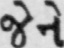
જેને
